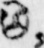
છે,
